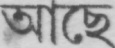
আছে
